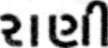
રાણી
